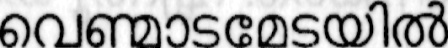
വെണ്മാടമേടയില്‍
